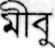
মীবু
